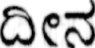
ದೀನ
